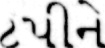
ટપીને
